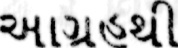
આગ્રહથી
